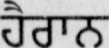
ਹੈਰਾਨ
